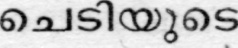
ചെടിയുടെ
